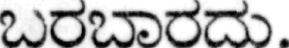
ಬರಬಾರದು.
